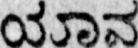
ಯಾವ
